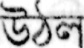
উঠল
